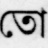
তো
